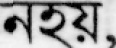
নহয়,
